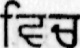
ਵਿਚ
